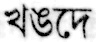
খঙদে
